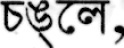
চঙলে,
